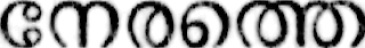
നേരത്തെ
